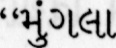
"મુંગલા
